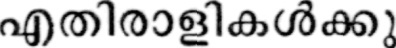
എതിരാളികള്‍ക്കു
